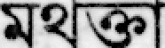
মথক্তা
